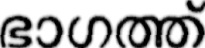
ഭാഗത്ത്
